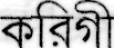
করিগী
